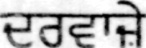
ਦਰਵਾਜ਼ੇ
